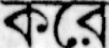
করে
